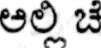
ಅಲ್ಲಿಚೆ
